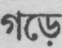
গড়ে
